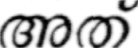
അത്
